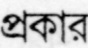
প্রকার
